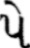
પે
